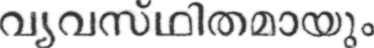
വ്യവസ്ഥിതമായും
